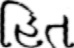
હિત
